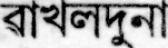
ৱাখলদুনা
